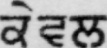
ਕੇਵਲ
